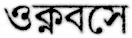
ওক্নবসে
